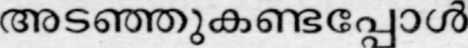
അടഞ്ഞുകണ്ടപ്പോള്‍
